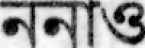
ননাও
